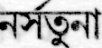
নর্সতুনা
